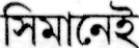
সিমানেই
